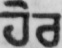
ਹੋਰ
